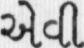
એવી
